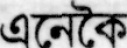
এনেকৈ
